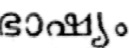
ഭാഷ്യം
